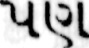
પણ
